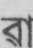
ৱা
